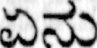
ಏನು
